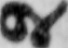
જ
